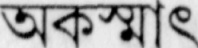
অকস্মাৎ
